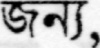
জন্য,
